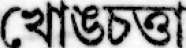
খোঙচত্তা
